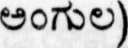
ಅಂಗುಲ)
